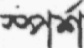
স্পর্শ
